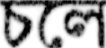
চলে
